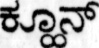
ಕ್ಹೂನ್
